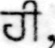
ਹੀ,
